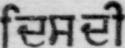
ਦਿਸਦੀ
